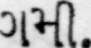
ગમી.
